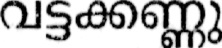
വട്ടക്കണ്ണു
